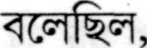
বলেছিল,
